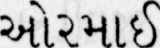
ઓરમાઈ
